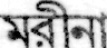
মরীনা
